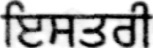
ਇਸਤਰੀ
